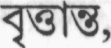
বৃত্তান্ত,
